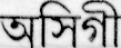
অসিগী
